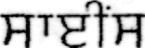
ਸਾਈਂਸ
